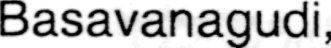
Basavanagudi,
